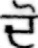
ਦੋ
